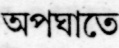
অপঘাতে
